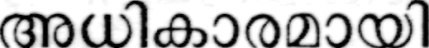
അധികാരമായി
